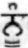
ਨੂੰ
